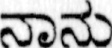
ನಾನು
